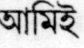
আমিই
